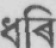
ধৰি
